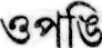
ওপঙি
